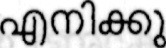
എനിക്കു
